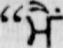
''ਮੈਂ
